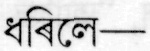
ধৰিলে-
